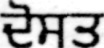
ਦੋਸਤ
